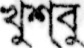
খুশ্বু
